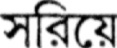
সরিয়ে
